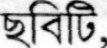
ছবিটি,
